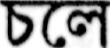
চলে
